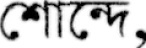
শোন্দে,
